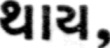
થાય,
